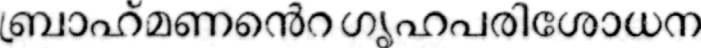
ബ്രാഹ്മണന്റെഗൃഹപരിശോധന
